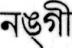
নঙগী
